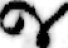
જ
